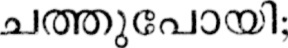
ചത്തുപോയി;
